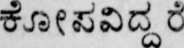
ಕೋಪವಿದ್ದರೆ
